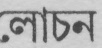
লোচন
